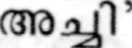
അച്ചി'
